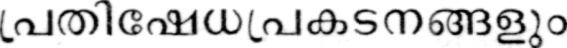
പ്രതിഷേധപ്രകടനങ്ങളും
